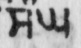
ਸੰਘ
